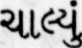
ચાલ્યું
